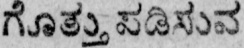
ಗೊತ್ತುಪಡಿಸುವ
